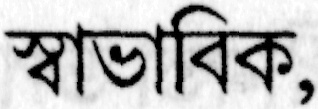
স্বাভাবিক,
